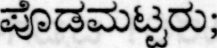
ಪೊಡಮಟ್ಟರು;
